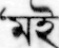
'মই
